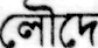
লৌদে
